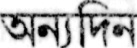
অন্যদিন
